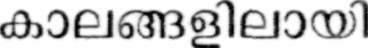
കാലങ്ങളിലായി
